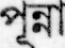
পুন্না
